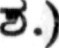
ಶ.)
